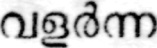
വളര്‍ന്ന
